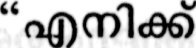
“എനിക്ക്
